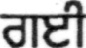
ਗਈ
